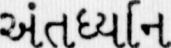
અંતર્ધ્યાન
